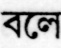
বলে
